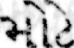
મોટે
